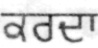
ਕਰਦਾ
